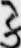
કે
